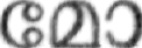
മോ
